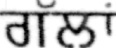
ਗੱਲਾਂ
